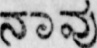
ನಾವು
